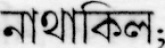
নাথাকিল;
